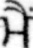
ਮੈਂ
